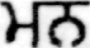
ਮਨ
